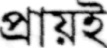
প্রায়ই
